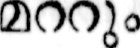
മററും
